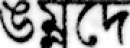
ঙম্নদে
